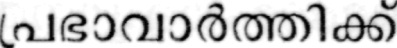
പ്രഭാവാര്‍ത്തിക്ക്
